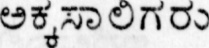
ಅಕ್ಕಸಾಲಿಗರು
